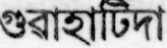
গুৱাহাটিদা
